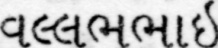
વલ્લભભાઈ
